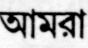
আমরা
